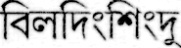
বিলদিংশিংদু
